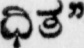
ಧಿತ”
